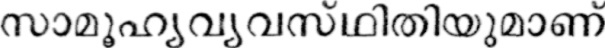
സാമൂഹ്യവ്യവസ്ഥിതിയുമാണ്
